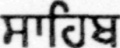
ਸਾਹਿਬ
